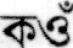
কওঁ
